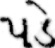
પડે
